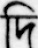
দি
